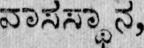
ವಾಸಸ್ಥಾನ,
